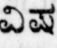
ವಿಷ
